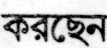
করছেন
